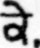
ਕੇ,
